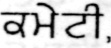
ਕਮੇਟੀ,
